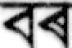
বৰ
